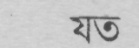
যত
